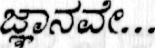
ಜ್ಞಾನವೇ.....
